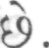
છે.
